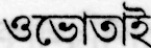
ওভোতাই
